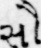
સૌ
